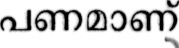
പണമാണ്
